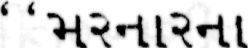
"મરનારના
